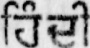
ਹਿੰਦੀ
